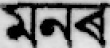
মনৰ
